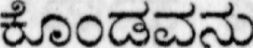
ಕೊಂಡವನು
